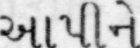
આપીને
